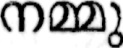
നമ്മു
